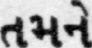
તમને
